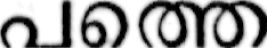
പത്തെ
